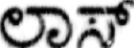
ಲಾಸ್
